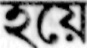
হয়ে
